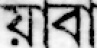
য়াবা
